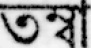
তম্বা
